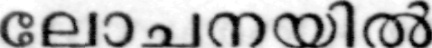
ലോചനയില്‍
